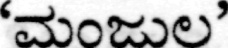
‘ಮಂಜುಲ’
